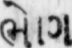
ભોગ
